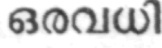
ഒരവധി
